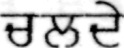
ਚਲਦੇ
